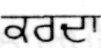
ਕਰਦਾ
